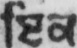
ਇਕ
